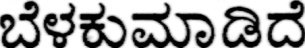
ಬೆಳಕುಮಾಡಿದೆ
